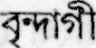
বৃন্দাগী
